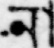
না
